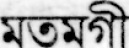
মতমগী
